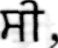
ਸੀ,
